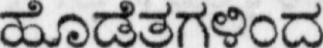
ಹೊಡೆತಗಳಿಂದ
